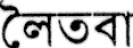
লৈতবা
